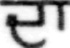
ਦਾ
